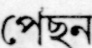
পেছন
